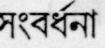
সংবর্ধনা
